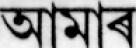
আমাৰ
